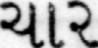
ચાર
